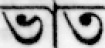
ভাত
